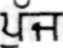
ਪੁੱਜ
